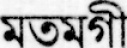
মতমগী
